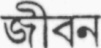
জীবন
